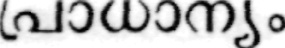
പ്രാധാന്യം
